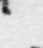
એ
